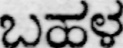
ಬಹಳ
